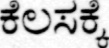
ಕೆಲಸಕ್ಕೆ
